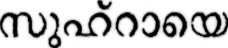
സുഹ്റായെ
